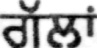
ਗੱਲਾਂ
